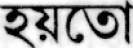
হয়তো
